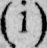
(i)
